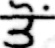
ਤੋਂ
